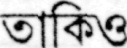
তাকিও
